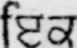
ਇਕ
